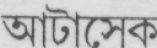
আটাসেক
